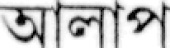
আলাপ
